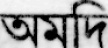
অমদি
